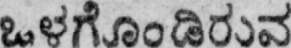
ಒಳಗೊಂಡಿರುವ
